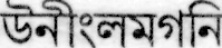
উনীংলমগনি
